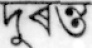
দুৰন্ত
